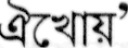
ঐখোয়’
